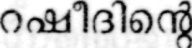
റഷീദിന്റെ
